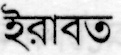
ইরাবত
